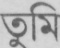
তুমি
